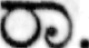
ರಾ.
